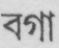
বগা
